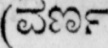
(ವರ್ಣ
